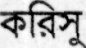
করিসু
